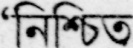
‘নিশ্চিত
